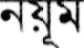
নয়ুম
